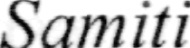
Samiti
